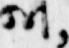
જા,
